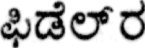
ಫಿಡೆಲ್ ರ
